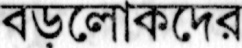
বড়লোকদের
